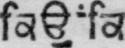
ਕਿਉਂਕਿ
